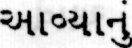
આવ્યાનું
